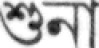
শুনা
